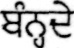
ਬੰਨ੍ਹਦੇ
